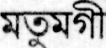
মতুমগী
